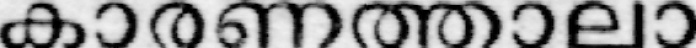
കാരണത്താലാ
